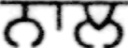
ਨਾਲ
